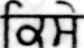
ਕਿਸੇ
